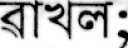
ৱাখল;
